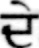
ਦੇ
